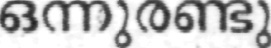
ഒന്നുരണ്ടു
